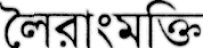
লৈরাংমক্তি
